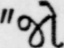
"જો
